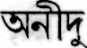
অনীদু
